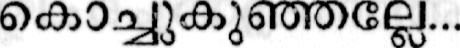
കൊച്ചുകുഞ്ഞല്ലേ...
